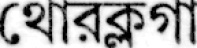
থোরক্লগা
